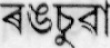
ৰঙচুৱা
